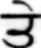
ਤੇ
